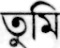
তুমি
